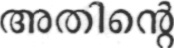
അതിന്റെ
